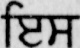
ਇਸ
